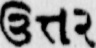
ઉત્તર
